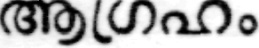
ആഗ്രഹം
